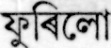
ফুৰিলো
